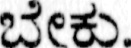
ಬೇಕು.
